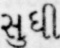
સુધી
